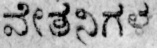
ವೇತನಿಗಳ
